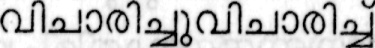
വിചാരിച്ചുവിചാരിച്ച്
